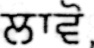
ਲਾਵੋ,
